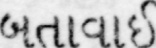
બતાવાઈ
